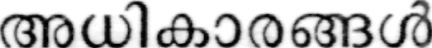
അധികാരങ്ങള്‍
